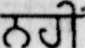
ਨਹੀਂ
